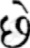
છે
